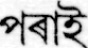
পৰাই
